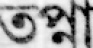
তপ্না
